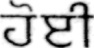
ਹੋਈ
